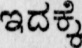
ಇದಕ್ಕೆ
